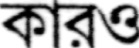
কারও
